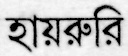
হায়রুরি
